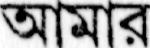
আমার
